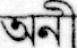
অনী
